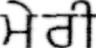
ਮੇਰੀ
